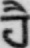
ਹੈ
